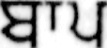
ਬਾਪ
